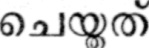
ചെയ്തത്
